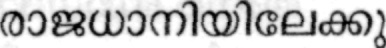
രാജധാനിയിലേക്കു
